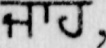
ਜਾਹ,
